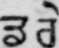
ਡਰੇ
